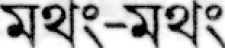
মথং-মথং
